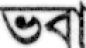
ভবা
